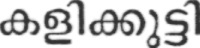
കളിക്കുട്ടി
